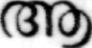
ആ
